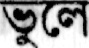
ভুলে
